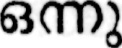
ഒന്നു
